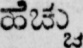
ಹೆಚ್ಚು
